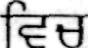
ਵਿਚ
